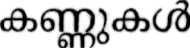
കണ്ണുകള്‍
